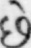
છે
